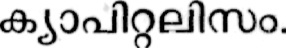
ക്യാപിറ്റലിസം.
